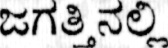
ಜಗತ್ತಿನಲ್ಲಿ
